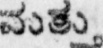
ಮತ್ತು
